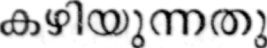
കഴിയുന്നതു
